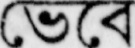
ভেবে
